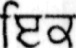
ਇਕ
